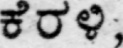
ಕೆರಳಿ,
